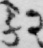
કેર
